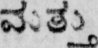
ಮತ್ತು
